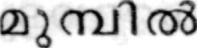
മുമ്പില്‍
